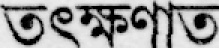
তৎক্ষণাত
